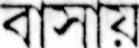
বাসায়
